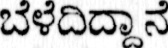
ಬೆಳೆದಿದ್ದಾನೆ
